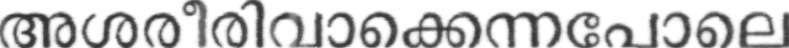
അശരീരിവാക്കെന്നപോലെ
